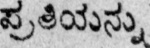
ಪ್ರತಿಯನ್ನು
